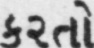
કરતો
